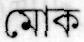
মোক
